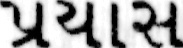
પ્રયાસ
